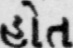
હોત
